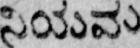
ನಿಯಮ
